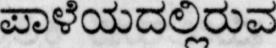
ಪಾಳೆಯದಲ್ಲಿರುವ
